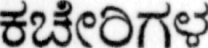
ಕಚೇರಿಗಳ
